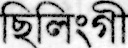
ছিলিংগী
